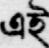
এই
